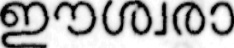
ഈശ്വരാ
